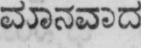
ಮಾನವಾದ
